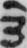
ਤੇ
